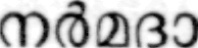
നര്‍മദാ
